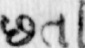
છતાં
